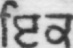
ਇਕ
